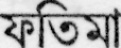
ফতিমা
